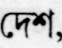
দেশ,
